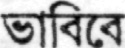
ভাবিবে
